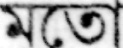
মতো
